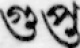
গুপ্ত
